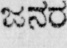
ಜನರ
